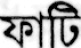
ফাটি
